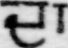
ਦਾ
